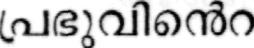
പ്രഭുവിന്റെ
